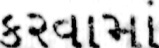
કરવામાં
